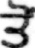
ਤੋਂ
